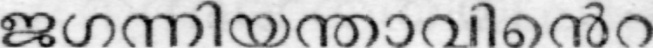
ജഗന്നിയന്താവിന്റെ
